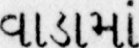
વાડામાં
